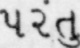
પરંતુ
